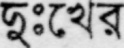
দুঃখের
